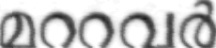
മററവര്‍
